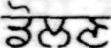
ਡੋਲਣ
